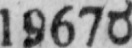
1967ರ
